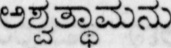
ಅಶ್ವತ್ಥಾಮನು
